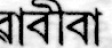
ৱাবীবা
